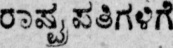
ರಾಷ್ಟ್ರಪತಿಗಳಿಗೆ
